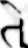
તે
